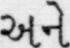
અને
